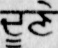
ਦੂਣੇ
